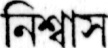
নিশ্বাস
